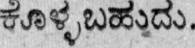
ಕೊಳ್ಳಬಹುದು.
